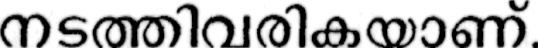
നടത്തിവരികയാണ്.
